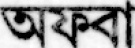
অফবা
